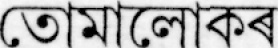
তোমালোকৰ
